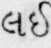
લઈ
